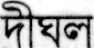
দীঘল
